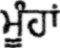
ਮੂੰਹਾਂ
